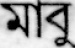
মাবু
